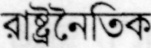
রাষ্ট্রনৈতিক
